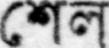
শেল
